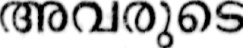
അവരുടെ
